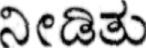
ನೀಡಿತು
